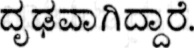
ದೃಢವಾಗಿದ್ದಾರೆ.
